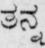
ತನ್ನ
